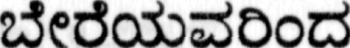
ಬೇರೆಯವರಿಂದ
